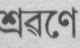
শ্ৰৱণে
